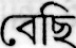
বেছি
